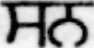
ਸਨ
